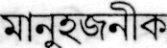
মানুহজনীক
